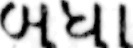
બધા
